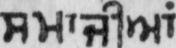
ਸਮਾਜੀਆਂ
